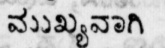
ಮುಖ್ಯವಾಗಿ
